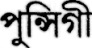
পুন্সিগী
